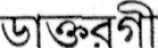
ডাক্তরগী
